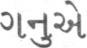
ગનુએ
